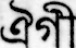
ঐগী
